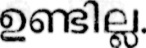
ഉണ്ടില്ല.
